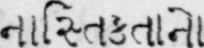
નાસ્તિકતાનો
